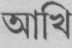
আখি
